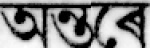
অন্তৰে
